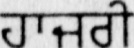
ਹਾਜਰੀ
